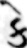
કે
